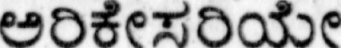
ಅರಿಕೇಸರಿಯೇ
